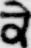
ਕੇ
